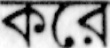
করে
